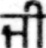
ਜੀ
